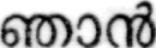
ഞാന്‍
